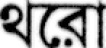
থরো
